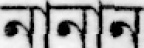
নানান
